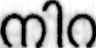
നിറ
